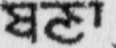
ਬਣਾ
